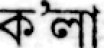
ক'লা
